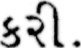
કરી.
